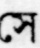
সে
